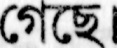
গেছে।
